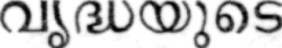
വൃദ്ധയുടെ
